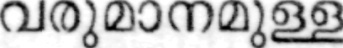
വരുമാനമുള്ള
